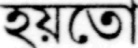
হয়তো
